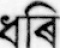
ধৰি
